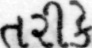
તરીકે
